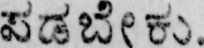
ಪಡಬೇಕು.
